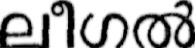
ലീഗല്‍
